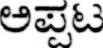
ಅಪ್ಪಟ
